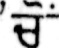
'ਚੋਂ
